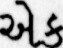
એક
